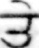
ਤੇ
